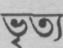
ভৃত্য
